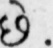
છે.
